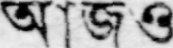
আজও
